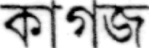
কাগজ
